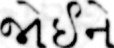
જોઈને
